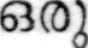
ഒരു
